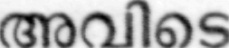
അവിടെ
